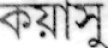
কয়াসু
